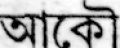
আকৌ
